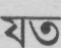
যত
